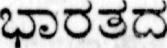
ಭಾರತದ
